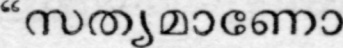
"സത്യമാണോ
